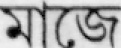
মাজে
